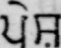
ਪੇਸ਼
